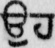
ਉਹ
